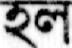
হল
